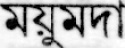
ময়ুমদা
